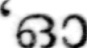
‘ഓ
